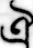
ঐ
